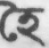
হৈ
